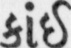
કાંઈ
